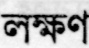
লক্ষণ
